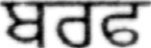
ਬਰਫ਼
